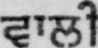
ਵਾਲੀ
